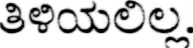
ತಿಳಿಯಲಿಲ್ಲ.
